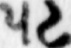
પટ
